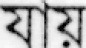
যায়
